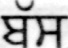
ਬੱਸ
